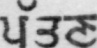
ਪੱਤਣ
